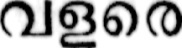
വളരെ
